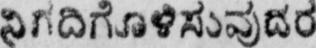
ನಿಗದಿಗೊಳಿಸುವುದರ
